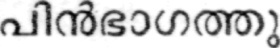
പിന്‍ഭാഗത്തു
